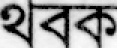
থবক
